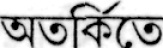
অতর্কিতে
